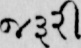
જરૂરી
